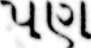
પણ
